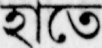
হাতে
